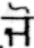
ਜੋ
